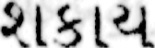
શકાય
